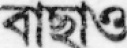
বাছাও
